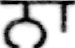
ਨਾ
